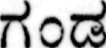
ಗಂಡ
